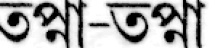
তপ্না-তপ্না
